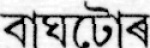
বাঘটোৰ
